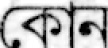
কোন
